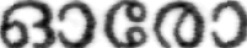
ഓരോ
